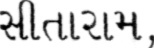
સીતારામ,
